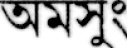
অমসুং
